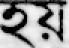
হয়
